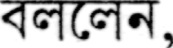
বললেন,
